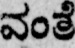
ವಂತೆ
